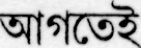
আগতেই
